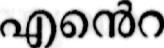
എന്റെ
